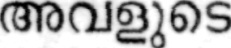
അവളുടെ
